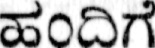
ಹಂದಿಗೆ
